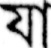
যা
